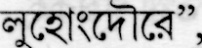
লুহোংদৌরে”,
